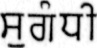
ਸੁੰਗਧੀ
